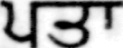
ਪਤਾ
